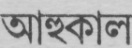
আহুকাল
